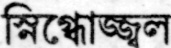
স্নিগ্ধোজ্জ্বল
